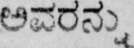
ಅವರನ್ನು
